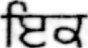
ਇਕ
